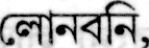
লোনবনি,
